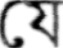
যে
